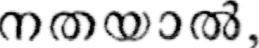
നതയാല്‍,
